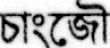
চাংজৌ
